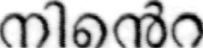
നിന്റെ
